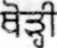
ਥੋੜ੍ਹੀ
